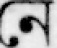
নে
